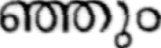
ഞ്ഞും
